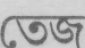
তেজ
